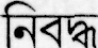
নিবদ্ধ
